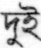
দুই
